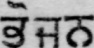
ਭੋਜਨ
